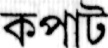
কপাট
